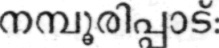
നമ്പൂരിപ്പാട്:
